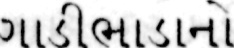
ગાડીભાડાનો
